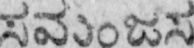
ಸಮಂಜಸ
